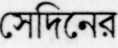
সেদিনের
